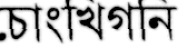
চোংখিগনি
